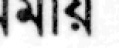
মমায়
